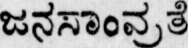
ಜನಸಾಂವ್ರತೆ
